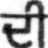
ਦੀ
